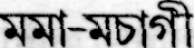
মমা-মচাগী
